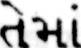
તેમાં
